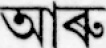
আৰু
